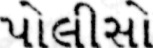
પોલીસો
